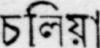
চলিয়া
